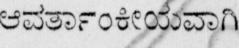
ಆವರ್ತಾಂಕೀಯವಾಗಿ
